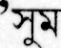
’সুম
